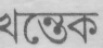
খন্তেক
